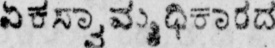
ಏಕಸ್ವಾಮ್ಯಧಿಕಾರದ
